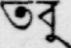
তবু
